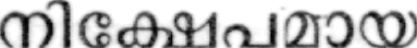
നിക്ഷേപമായ
